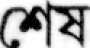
শেষ
